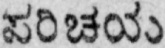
ಪರಿಚಯ
